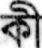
কী
